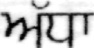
ਅੱਧਾ
